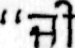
''ਜੀ
